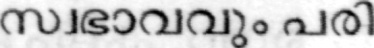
സ്വഭാവവുംപരി
